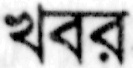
খবর
